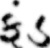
ફંડ
